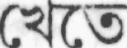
খেতে
